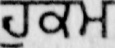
ਹੁਕਮ
